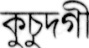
কুচুদগী
